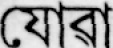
যোৱা
